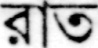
রাত
